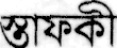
স্তাফকী
